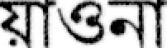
য়াওনা
